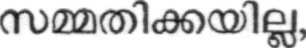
സമ്മതിക്കയില്ല,
